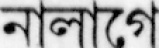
নালাগে
